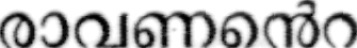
രാവണന്റെ
